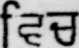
ਵਿਚ
